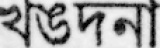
খঙদনা
